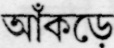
আঁকড়ে
